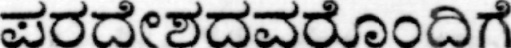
ಪರದೇಶದವರೊಂದಿಗೆ
